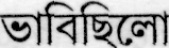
ভাবিছিলো
